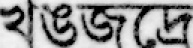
খঙজদ্রে
